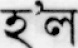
হ'ল
